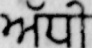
ਅੱਧੀ
